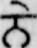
ਨੇ
